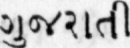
ગુજરાતી
